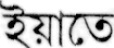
ইয়াতে
